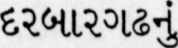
દરબારગઢનું
